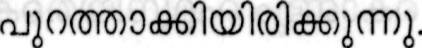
പുറത്താക്കിയിരിക്കുന്നു.
